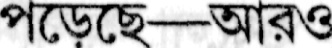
পড়েছে–আরও
